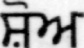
ਸ਼ੋਅ
